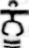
ਨੂੰ
